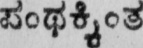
ಪಂಥಕ್ಕಿಂತ
